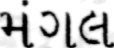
મંગલ
